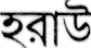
হরাউ
